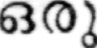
ഒരു
